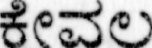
ಕೇವಲ
